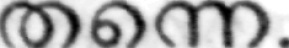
തന്നെ.
